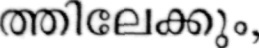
ത്തിലേക്കും,
